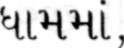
ધામમાં,
